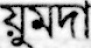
য়ুমদা
